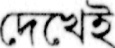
দেখেই
